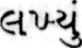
લખ્યું
